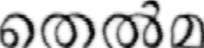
തെല്‍മ
